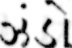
ઝંડો
